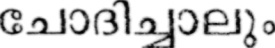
ചോദിച്ചാലും
